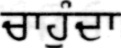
ਚਾਹੁੰਦਾ
